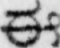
ಈ
